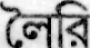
লৈরি
